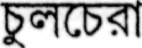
চুলচেরা
